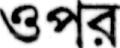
ওপর
